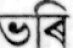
ভৰি
